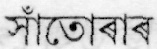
সাঁতোৰাৰ
